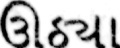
ઊઠ્યા
